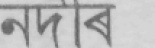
নদীৰ
